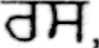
ਰਸ,
